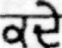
ਕਦੇ
